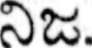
ನಿಜ.
